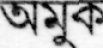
অমুক
